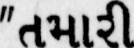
"તમારી
